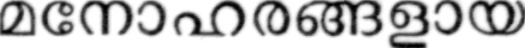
മനോഹരങ്ങളായ
